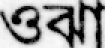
ওঝা
